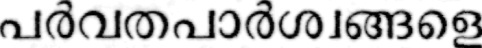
പര്‍വതപാര്‍ശ്വങ്ങളെ
